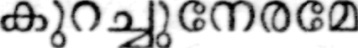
കുറച്ചുനേരമേ
